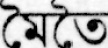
মৈতৈ
